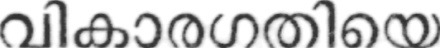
വികാരഗതിയെ
